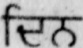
ਦਿਨ
